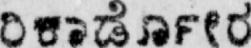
ರಿಕಾರ್ಡೋರ
